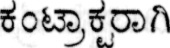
ಕಂಟ್ರಾಕ್ಟರಾಗಿ
